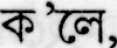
ক'লে,
